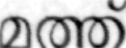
മത്ത്
